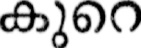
കുറെ
